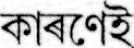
কাৰণেই
